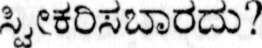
ಸ್ವೀಕರಿಸಬಾರದು?
